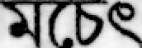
মচেৎ
